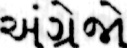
અંગ્રેજો
